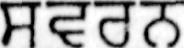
ਸਵਰਨ
